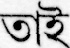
তাই
